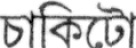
চাকিটো
